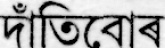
দাঁতিবোৰ
